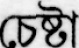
চেষ্টা
